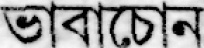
ভাবাচোন
